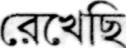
রেখেছি
